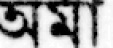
অমা
